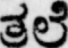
ತಲೆ
